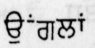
ਉਂਗਲਾਂ
